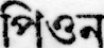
পিওন
